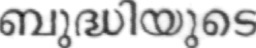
ബുദ്ധിയുടെ
